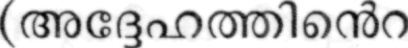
(അദ്ദേഹത്തിന്റെ
